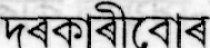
দৰকাৰীবোৰ
